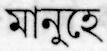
মানুহে
